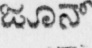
ಜೂನ್
